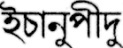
ইচানুপীদু
